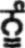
ਨੂੰ
